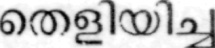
തെളിയിച്ച
